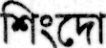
শিংদো
